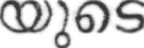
യുടെ
